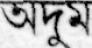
অদুম
